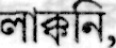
লাক্কনি,
